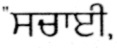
''ਸਚਾਈ,
